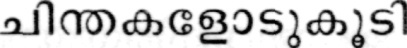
ചിന്തകളോടുകൂടി
